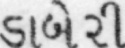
ડાબેરી
